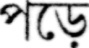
পড়ে
